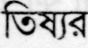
তিষ্যর
